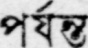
পর্যন্ত
